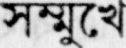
সম্মুখে
